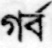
গর্ব
